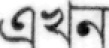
এখন
